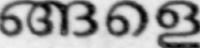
ങ്ങളെ
